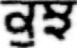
ਕੁਝ
